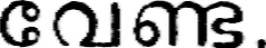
വേണ്ട.
